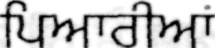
ਪਿਆਰੀਆਂ
